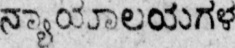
ನ್ಯಾಯಾಲಯಗಳ
